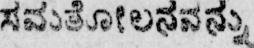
ಸಮತೋಲನವನ್ನು
